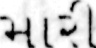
મારી
